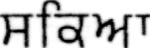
ਸਕਿਆ
